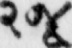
રજૂ
